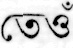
তেওঁ
